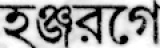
হঞ্জরগে
